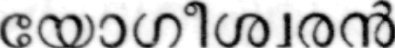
യോഗീശ്വരന്‍
